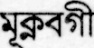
মূক্নবগী
